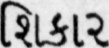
શિકાર
